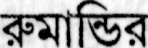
রুমান্ডির
